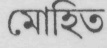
মোহিত
